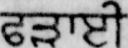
ਫੜਾਈ
